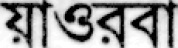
য়াওরবা
